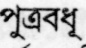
পুত্রবধূ
